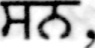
ਸਨ,
